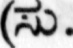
(ಸು.
